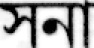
সনা
